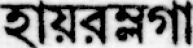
হায়রম্লগা
